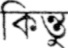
কিন্তু
